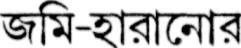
জমি-হারানোর
